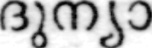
ദുന്യാ
